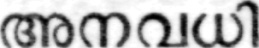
അനവധി
